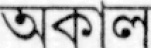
অকাল
